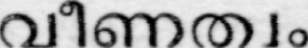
വീണത്വം
